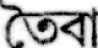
তৈবা
